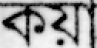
কয়া
